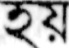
হয়
